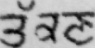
ਤੱਕਣ
